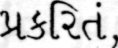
પ્રકરિતં,
